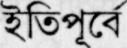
ইতিপূর্বে
